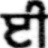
ਈ
